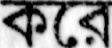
করে
